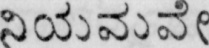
ನಿಯಮವೇ
